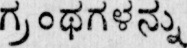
ಗ್ರಂಥಗಳನ್ನು
